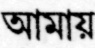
আমায়
